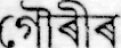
গৌৰীৰ
